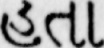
હતા
